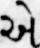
એ
